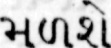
મળશે
